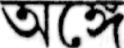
অঙ্গে
